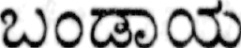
ಬಂಡಾಯ
